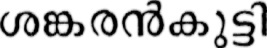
ശങ്കരന്‍കുട്ടി
